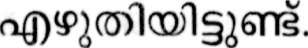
എഴുതിയിട്ടുണ്ട്.
